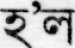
হ'ল
